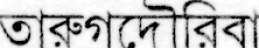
তারুগদৌরিবা
